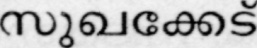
സുഖക്കേട്
